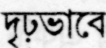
দৃঢ়ভাবে
